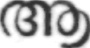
ആ
